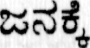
ಜನಕ್ಕೆ
